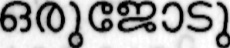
ഒരുജോടു
